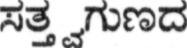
ಸತ್ತ್ವಗುಣದ
